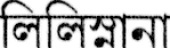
লিলিস্নানা
